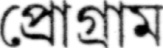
প্রোগ্রাম
